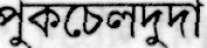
পুকচেলদুদা
